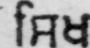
ਸਿਖ
